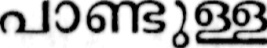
പാണ്ടുള്ള
